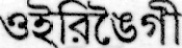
ওইরিঙৈগী
